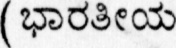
(ಭಾರತೀಯ
